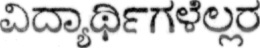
ವಿದ್ಯಾರ್ಥಿಗಳೆಲ್ಲರ
